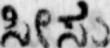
ಸೀಸು
